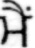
ਮੈਂ
